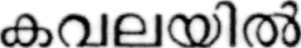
കവലയില്‍
